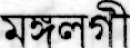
মঙ্গলগী
